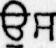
ਉਸ
